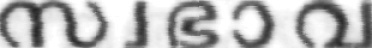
സ്വഭാവ
